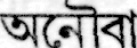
অনৌবা
